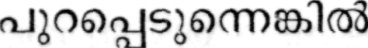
പുറപ്പെടുന്നെങ്കില്‍
